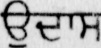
ਉਦਾਸ
